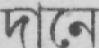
দানে
